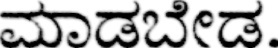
ಮಾಡಬೇಡ.
